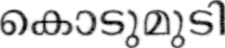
കൊടുമുടി
